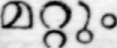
മറ്റും
